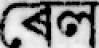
ৰেল
